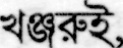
খঞ্জরুই,
